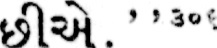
છીએ."૩૦૬
